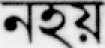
নহয়
